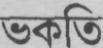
ভকতি
